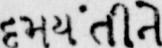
દમયંતીને
